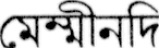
মেম্মীনদি
